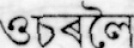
ওচৰলৈ
